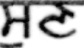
ਸੁਣ
